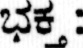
ಭಕ್ತ:
